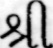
શ્રી
